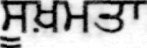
ਸੂਖ਼ਮਤਾ
